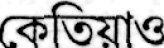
কেতিয়াও
